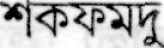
শকফমদু
